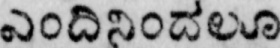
ಎಂದಿನಿಂದಲೂ
